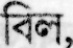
বিল,
